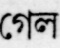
গেল
